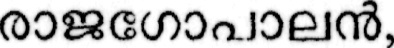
രാജഗോപാലന്‍,
